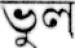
ভুল
